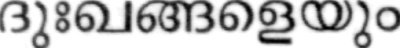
ദുഃഖങ്ങളെയും
